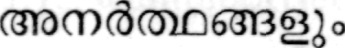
അനര്‍ത്ഥങ്ങളും
